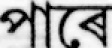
পাৰে
